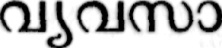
വ്യവസാ
